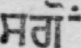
ਸਗੋਂ
